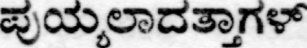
ಪುಯ್ಯಲಾದತ್ತಾಗಳ್
